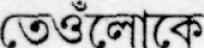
তেওঁলোকে
